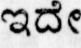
ಇದೇ
